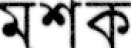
মশক
